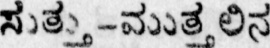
ಸುತ್ತು-ಮುತ್ತಲಿನ
